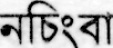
নচিংবা
